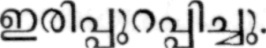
ഇരിപ്പുറപ്പിച്ചു.
